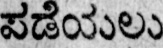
ಪಡೆಯಲು
